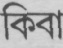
কিবা
